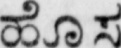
ಹೊಸ
